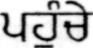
ਪਹੁੰਚੇ
